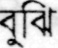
বুঝি
